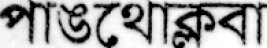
পাঙথোক্লবা
